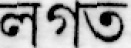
লগত
